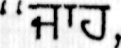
''ਜਾਹ,
